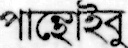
পান্থোইবু
